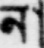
না
